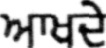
ਆਖਦੇ
